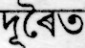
দূৰৈত
